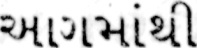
આગમાંથી
